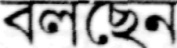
বলছেন
